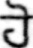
ਹੋ
